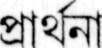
প্রার্থনা
